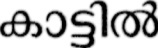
കാട്ടില്‍
